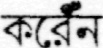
করেন
